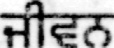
ਜੀਵਨ
